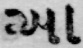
આ
